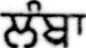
ਲੰਬਾ
